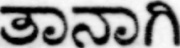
ತಾನಾಗಿ
